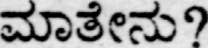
ಮಾತೇನು?
